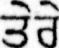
ਤੇਰੇ
